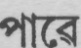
পাৱে
